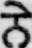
ਨੇ
